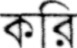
করি
